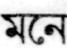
মনে
